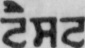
ਟੈਸਟ
